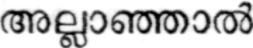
അല്ലാഞ്ഞാല്‍
